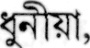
ধুনীয়া,
